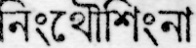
নিংথৌশিংনা
